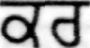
ਕਰ
